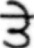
ਤੇ
